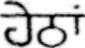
ਹੇਠਾਂ
